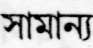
সামান্য
